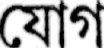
যোগ
